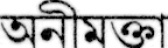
অনীমক্তা
